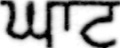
ਘਾਟ
